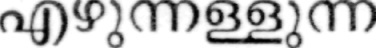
എഴുന്നള്ളുന്ന
